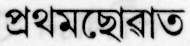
প্রথমছোৱাত
